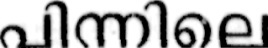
പിന്നിലെ
